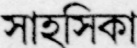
সাহসিকা
